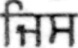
ਜਿਸ
